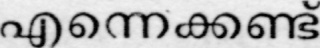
എന്നെക്കണ്ട്
